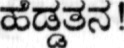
ಹೆಡ್ಡತನ!
